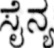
ಸೈನ್ಯ
